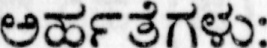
ಅರ್ಹತೆಗಳು:
